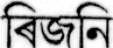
ৰিজনি
